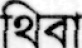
থিবা
